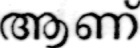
ആണ്
